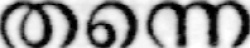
തന്നെ
